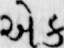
એક
